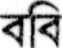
ববি
